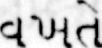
વખતે
